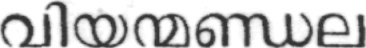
വിയന്മണ്ഡല
